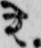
રે.
